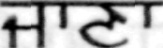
ਜਾਣਾ
